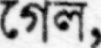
গেল,
